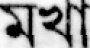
মখা
